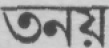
তনয়
